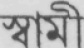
স্বামী
